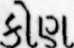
કોણ
